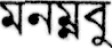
মনম্নবু
